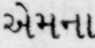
એમના
